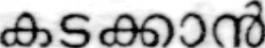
കടക്കാന്‍
